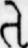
તે
